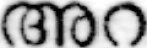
അറ
